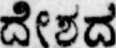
ದೇಶದ
